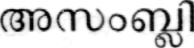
അസംബ്ലി
